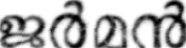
ജര്‍മന്‍
